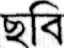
ছবি
